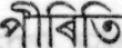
পীৰিতি
